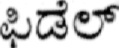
ಫಿಡೆಲ್
